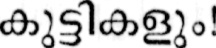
കുട്ടികളും!
